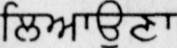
ਲਿਆਉਣਾ
